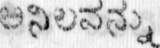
ಅನಿಲವನ್ನು
